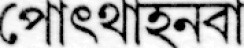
পোৎথাহনবা
